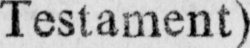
Testament)
